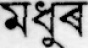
মধুৰ
